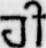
ਹੀ
